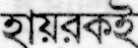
হায়রকই
